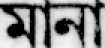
মানা
